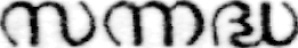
സന്നദ്ധ
